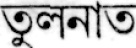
তুলনাত
